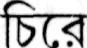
চিরে
